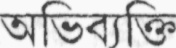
অভিব্যক্তি
